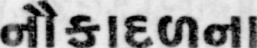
નૌકાદળના
